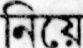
নিয়ে
